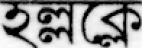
হল্লক্লে
